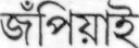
জঁপিয়াই
